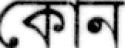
কোন
